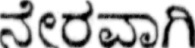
ನೇರವಾಗಿ
